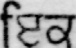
ਇਕ
